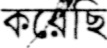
করেছি
